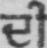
ਦੀ
